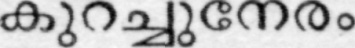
കുറച്ചുനേരം
